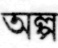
অল্প
